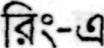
রিং-এ
